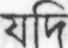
যদি
